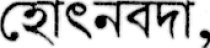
হোৎনবদা,
